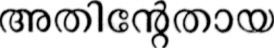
അതിന്റേതായ
